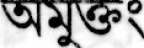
অমুক্তং
